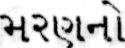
મરણનો
